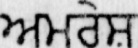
ਅਮਰੇਸ਼
